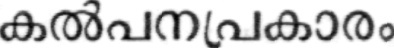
കല്‍പനപ്രകാരം
